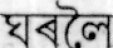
ঘৰলৈ
